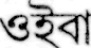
ওইবা
